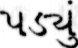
પડ્યું
